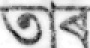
তাৰ
